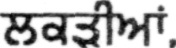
ਲਕੜੀਆਂ,
